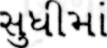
સુધીમાં
